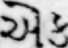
એક
